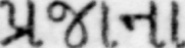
પ્રજાના
